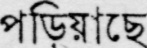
পড়িয়াছে
